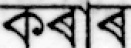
কৰাৰ
